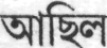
আছিল
